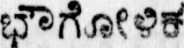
ಭೌಗೋಳಿಕ
